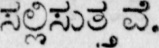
ಸಲ್ಲಿಸುತ್ತವೆ.
